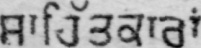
ਸਾਹਿੱਤਕਾਰਾਂ
